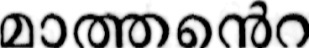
മാത്തന്റെ
